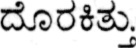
ದೊರಕಿತ್ತು.
